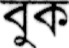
বুক
